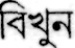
বিখুন
